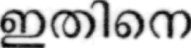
ഇതിനെ
